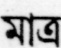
মাত্র
